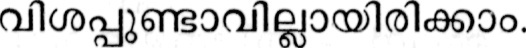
വിശപ്പുണ്ടാവില്ലായിരിക്കാം.
